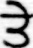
ਤੇ
